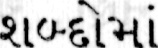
શબ્દોમાં
